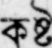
কষ্ট
